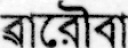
ৱারৌবা
